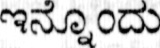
ಇನ್ನೊಂದು
